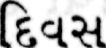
દિવસ
